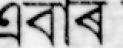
এবাৰ
